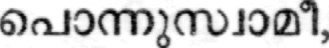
പൊന്നുസ്വാമീ,
